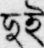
দুই
